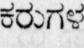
ಕರುಗಳ
